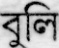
বুলি
